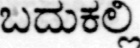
ಬದುಕಲ್ಲಿ
